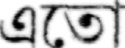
এতো
